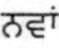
ਨਵਾਂ
